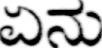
ಏನು
